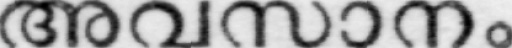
അവസാനം
